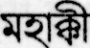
মহাক্কী
